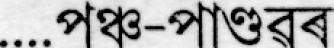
....পঞ্চ-পাণ্ডৱৰ
